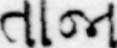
તાજા
